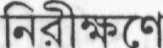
নিরীক্ষণে
